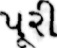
પૂરી
